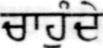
ਚਾਹੁੰਦੇ
